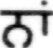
ਨਾਂ
